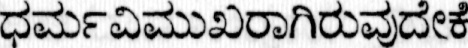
ಧರ್ಮವಿಮುಖರಾಗಿರುವುದೇಕೆ
